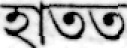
হাতত
